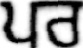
ਪਰ
